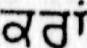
ਕਰਾਂ
